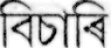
বিচাৰি
